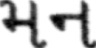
મન
